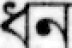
ধন
